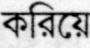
করিয়ে
